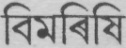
বিমৰিষি
